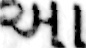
આ
